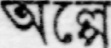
অল্পে
